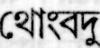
থোংবদু
